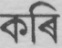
কৰি
